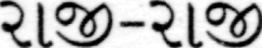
રાજી-રાજી
